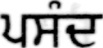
ਪਸੰਦ
